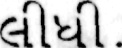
લીધી.
